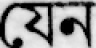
যেন
